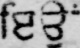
ਇਉਂ
